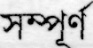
সম্পূর্ণ
